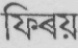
ফিৰয়
